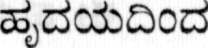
ಹೃದಯದಿಂದ
